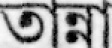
তান্না
